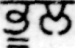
ਭੂਲ
